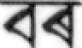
বৰ
